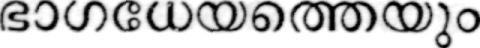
ഭാഗധേയത്തെയും
